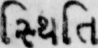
સ્થિતિ
